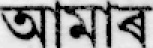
আমাৰ
